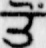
ਤੋਂ
